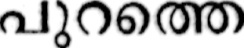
പുറത്തെ
